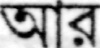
আর
